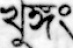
খুঙ্গং
